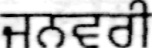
ਜਨਵਰੀ
